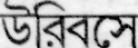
উরিবসে
